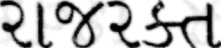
રાજરક્ત
